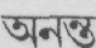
অনন্ত
